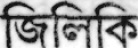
জিলিকি
